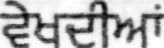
ਵੇਖਦੀਆਂ
